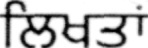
ਲਿਖਤਾਂ
